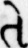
તે
